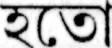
হতো
